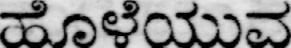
ಹೊಳೆಯುವ
